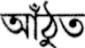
আঁঠুত
